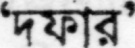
‘দফার’
